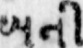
બની
